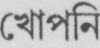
খোপনি
